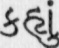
કહ્યું
